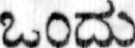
ಒಂದು
